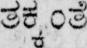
ತಕ್ಕಂತೆ
